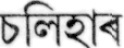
চলিহাৰ
